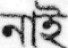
নাই
